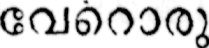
വേറൊരു
